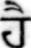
ਹੈ
